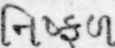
નિષ્ફળ
